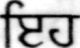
ਇਹ
